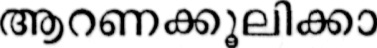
ആറണക്കൂലിക്കാ
